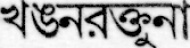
খঙনরক্তুনা
